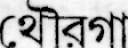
থৌরগা
